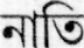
নাতি
